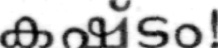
കഷ്ടം!
